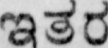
ಇತರ
